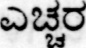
ಎಚ್ಚರ
